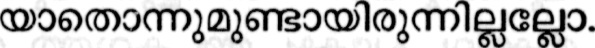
യാതൊന്നുമുണ്ടായിരുന്നില്ലല്ലോ.
